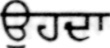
ਉਹਦਾ
